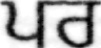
ਪਰ
